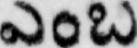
ಎಂಬ
